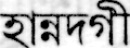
হান্নদগী
